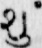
શું
